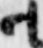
ન
